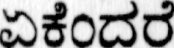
ಏಕೆಂದರೆ
